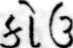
કોઉ
